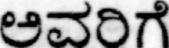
ಅವರಿಗೆ
